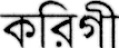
করিগী
